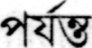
পর্যন্ত
